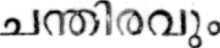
ചന്തിരവും
